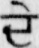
ਦੇ
